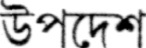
উপদেশ
